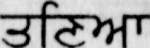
ਤਣਿਆ
